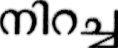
നിറച്ച
